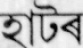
হাটৰ
